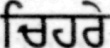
ਚਿਹਰੇ
